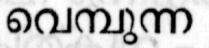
വെമ്പുന്ന
